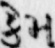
કેમ
